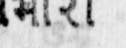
અમારી
